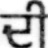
ਦੀ
